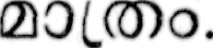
മാത്രം.
